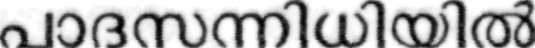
പാദസന്നിധിയില്‍
